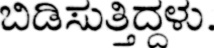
ಬಿಡಿಸುತ್ತಿದ್ದಳು.
